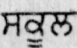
ਸਕੂਲ
